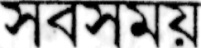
সবসময়
